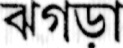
ঝগড়া
